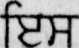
ਇਸ
